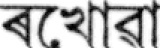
ৰখোৱা
